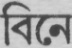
বিনে
